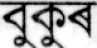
বুকুৰ
